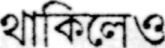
থাকিলেও
